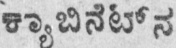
ಕ್ಯಾಬಿನೆಟ್‌ನ
